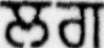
ਲਗ
